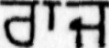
ਰਾਜ
